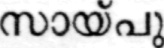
സായ്പു
